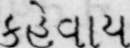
કહેવાય
